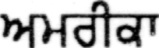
ਅਮਰੀਕਾ
